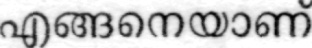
എങ്ങനെയാണ്
